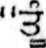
''ਤੂੰ
